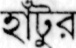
হাঁটুর
